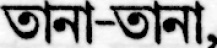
তানা-তানা,
